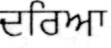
ਦਰਿਆ
